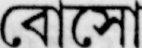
বোসো
